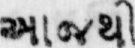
આજથી
